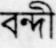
বন্দী
